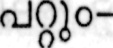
പറ്റും-
